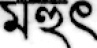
মহুৎ
